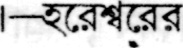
৷—হরেশ্বরের
